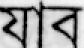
যাব
